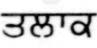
ਤਲਾਕ
